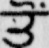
ਤੋਂ
